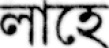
লাহে
